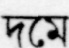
দমে
